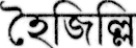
হৈজিল্লি
